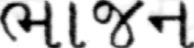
ભાજન
